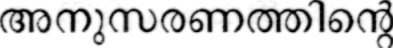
അനുസരണത്തിന്റെ
